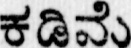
ಕಡಿಮೆ
